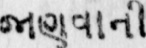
જાણવાની
